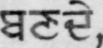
ਬਣਦੇ,
